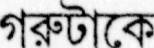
গরুটাকে
